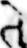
તે
